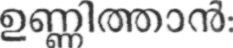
ഉണ്ണിത്താന്‍:
